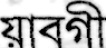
য়াবগী
